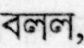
বলল,
